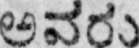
ಅವರು
